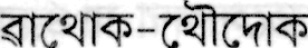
ৱাথোক-থৌদোক
